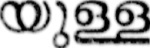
യുള്ള
